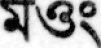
মওং
